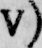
v)
